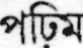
পঢ়িম
